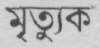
মৃত্যুক
